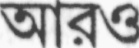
আরও
